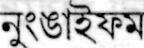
নুংঙাইফম
